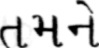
તમને
